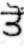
ਤੋਂ
